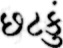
છટકું
